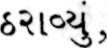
ઠરાવ્યું,
